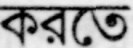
করতে
